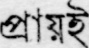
প্রায়ই
